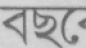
বছৰে
